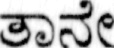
ತಾನೇ
